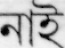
নাই
